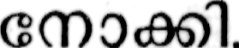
നോക്കി.
